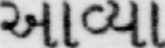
આવ્યા
